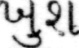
ખુશ
